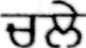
ਚਲੇ
